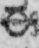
ಈ
